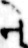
ને
